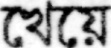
খেয়ে
